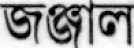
জঞ্জাল
